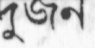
দুজন
